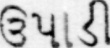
ઉપાડી
